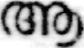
ആ
